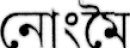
নোংমৈ
